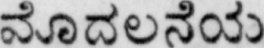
ಮೊದಲನೆಯ
